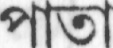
পাতা
